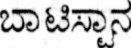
ಬಾಟಿಸ್ಟಾನ
